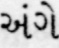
અંગે
